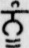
ਨੂੰ
